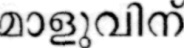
മാളുവിന്
